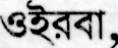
ওইরবা,
